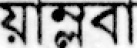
য়াম্লবা
